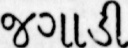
જગાડી
